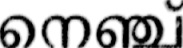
നെഞ്ച്
